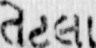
તેટલા
